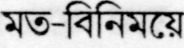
মত-বিনিময়ে
